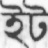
ইট
